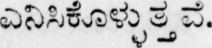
ಎನಿಸಿಕೊಳ್ಳುತ್ತವೆ.
